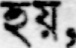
হয়,
